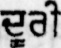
ਦੂਰੀ
